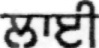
ਲਾਈ
